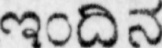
ಇಂದಿನ
